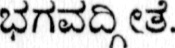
ಭಗವದ್ಗೀತೆ.
